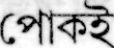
পোকই
